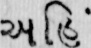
અહિં
